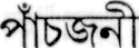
পাঁচজনী
